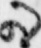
જે
